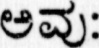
ಅವು:
